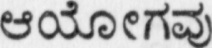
ಆಯೋಗವು
